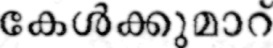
കേള്‍ക്കുമാറ്
